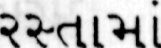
રસ્તામાં
